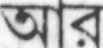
আর
